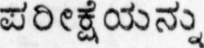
ಪರೀಕ್ಷೆಯನ್ನು
